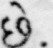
છે.
